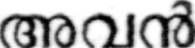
അവന്‍
